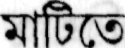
মাটিতে
